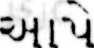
આપે
